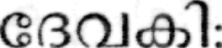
ദേവകി:
